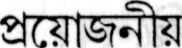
প্রয়োজনীয়
